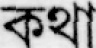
কথা
